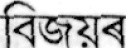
বিজয়ৰ
